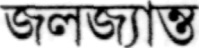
জলজ্যান্ত
